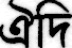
ঐদি
